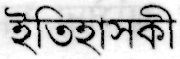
ইতিহাসকী
